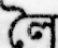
লৈ
